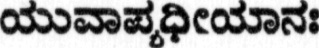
ಯುವಾಪ್ಯಧೀಯಾನಃ
